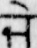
ਜੇ
